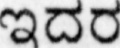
ಇದರ
